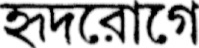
হৃদরোগে
